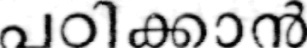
പഠിക്കാന്‍
